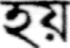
হয়
